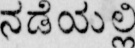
ನಡೆಯಲ್ಲಿ
